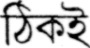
ঠিকই
